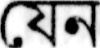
যেন
